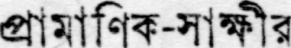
প্রামাণিক-সাক্ষীর
